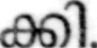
ക്കി.
